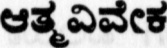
ಆತ್ಮವಿವೇಕ
